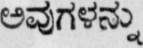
ಅವುಗಳನ್ನು
